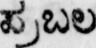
ಪ್ರಬಲ
